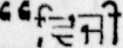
''ਵਿਜੀ
